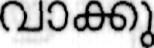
വാക്കു
